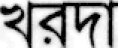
খরদা
